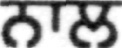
ਨਾਲ
